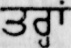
ਤਰ੍ਹਾਂ
